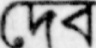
দেব
